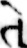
તે
